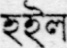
হইল
